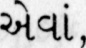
એવાં,
